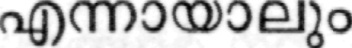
എന്നായാലും
